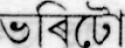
ভৰিটো
